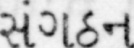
સંગઠન
